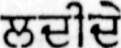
ਲਦੀਦੇ
